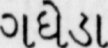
ગધેડા
